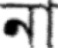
না
